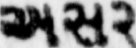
અસર
